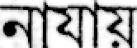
নাযায়
